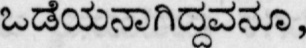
ಒಡೆಯನಾಗಿದ್ದವನೂ,
